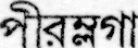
পীরম্লগা
